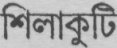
শিলাকুটি
